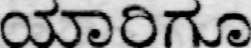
ಯಾರಿಗೂ
